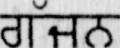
ਗੱਜਨ
